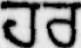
ਹਰ
